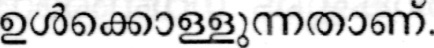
ഉള്‍ക്കൊള്ളുന്നതാണ്.
